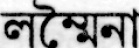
লম্মৈনা
